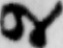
જ
